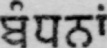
ਬੰਧਨਾਂ
